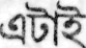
এটাই
